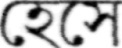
হেসে
